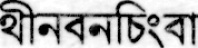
থীনবনচিংবা
